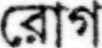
রোগ
